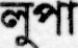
লুপা
